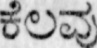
ಕೆಲವು
